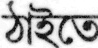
ঠাইতে
